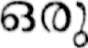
ഒരു
